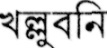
খল্লুবনি
